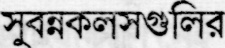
সুবন্নকলসগুলির
